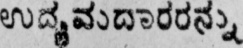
ಉದ್ಯಮದಾರರನ್ನು
